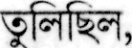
তুলিছিল,
